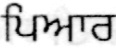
ਪਿਆਰ
